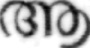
ആ
